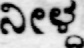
ನೀಳ್ದ
